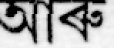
আৰু
